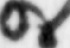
જ
